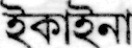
ইকাইনা
